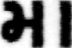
મા
